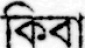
কিবা
